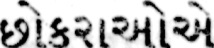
છોકરાઓએ
